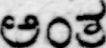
ಅಂತ
